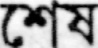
শেষ
